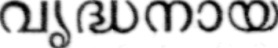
വൃദ്ധനായ
